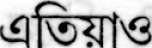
এতিয়াও
